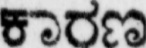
ಕಾರಣ
